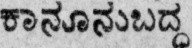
ಕಾನೂನುಬದ್ದ
